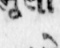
ભૂલી
